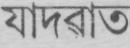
যাদৱাত
